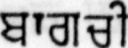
ਬਾਗਚੀ
